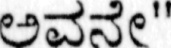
ಅವನೇ
